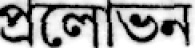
প্রলোভন
